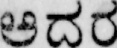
ಅದರ
